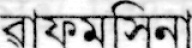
ৱাফমসিনা
